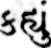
કહ્યું
